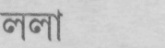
ললা
